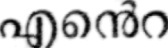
എന്റെ
